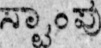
ಸ್ಟಾಂಪು
